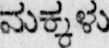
ಮಕ್ಕಳು
